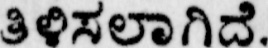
ತಿಳಿಸಲಾಗಿದೆ.
